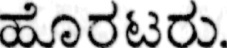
ಹೊರಟರು.
